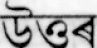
উত্তৰ
